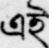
এই
